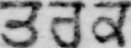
ਤਰਕ
